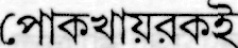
পোকখাইরকই
